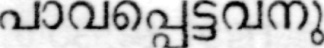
പാവപ്പെട്ടവനു
